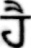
ਹੈ
